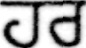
ਹਰ
